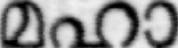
മഹാ
